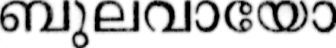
ബുലവായോ
